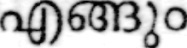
എങ്ങും
